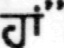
ਹਾਂ''
